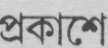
প্ৰকাশে
